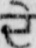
ਦੇ
